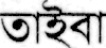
তাইবা
